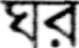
ঘর
